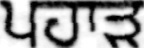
ਪਹਾੜ
